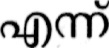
എന്ന്
